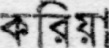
করিয়া
